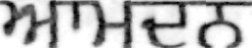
ਆਮਦਨ
